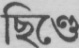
ছিণ্ডে
